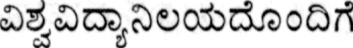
ವಿಶ್ವವಿದ್ಯಾನಿಲಯದೊಂದಿಗೆ
